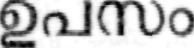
ഉപസം
